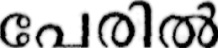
പേരില്‍
